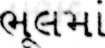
ભૂલમાં
